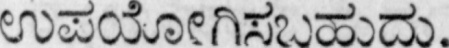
ಉಪಯೋಗಿಸಬಹುದು.
